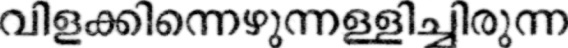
വിളക്കിന്നെഴുന്നള്ളിച്ചിരുന്ന
